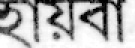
হায়বা
